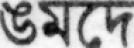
ঙমদে
